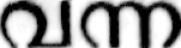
വന്ന
